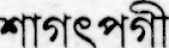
শাগৎপগী
